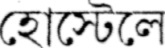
হোস্টেলে
